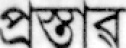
প্রস্তাৱ
